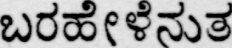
ಬರಹೇಳೆನುತ
